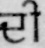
ਦੀ
